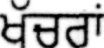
ਖੱਚਰਾਂ
